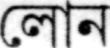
লোন
